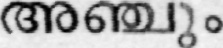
അഞ്ചും
